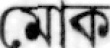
মোক
